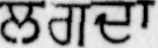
ਲਗਦਾ
